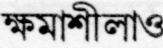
ক্ষমাশীলাও
